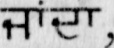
ਜਾਂਦਾ,
